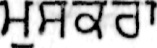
ਮੁਸਕਰਾ
